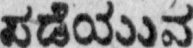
ಪಡೆಯುವ
